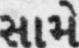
સામે
